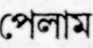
পেলাম
